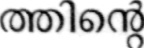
ത്തിന്റെ
